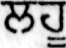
ਲਹੂ
